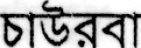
চাউরবা
